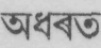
অধৰত
